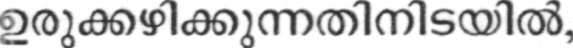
ഉരുക്കഴിക്കുന്നതിനിടയില്‍,
